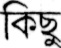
কিছু
